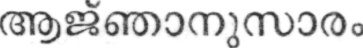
ആജ്ഞാനുസാരം
